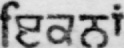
ਇਕਨਾਂ
